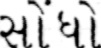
સોંધો
